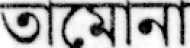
তামোনা
